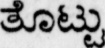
ತೊಟ್ಟು
